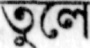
তুলে
